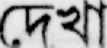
দেখা
